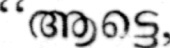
"ആട്ടെ,
